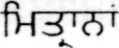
ਮਿਤ੍ਰਾਨਾਂ
